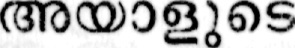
അയാളുടെ
